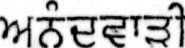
ਅਨੰਦਵਾੜੀ
